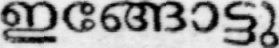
ഇങ്ങോട്ടു
